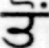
ਤੋਂ
